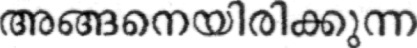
അങ്ങനെയിരിക്കുന്ന
